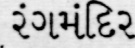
રંગમંદિર
